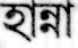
হান্না
